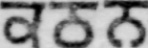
ਕਠਨ
